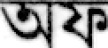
অফ
